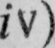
iv)
